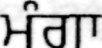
ਮੰਗਾ
